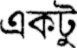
একটু
